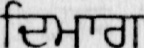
ਦਿਮਾਗ
